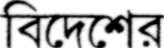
বিদেশের
